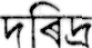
দৰিদ্র
